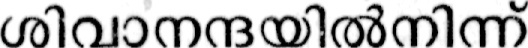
ശിവാനന്ദയില്‍നിന്ന്
